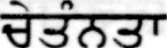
ਚੇਤੰਨਤਾ
